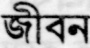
জীবন
